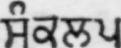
ਸੰਕਲਪ
